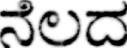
ನೆಲದ
